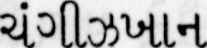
ચંગીઝખાન
